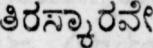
ತಿರಸ್ಕಾರವೇ
